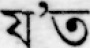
য'ত
